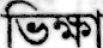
ভিক্ষা
